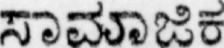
ಸಾಮಾಜಿಕ
